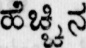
ಹೆಚ್ಚಿನ
